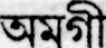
অমগী
